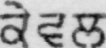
ਕੇਵਲ
